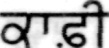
ਕਾਫ਼ੀ
